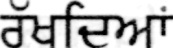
ਰੱਖਦਿਆਂ
